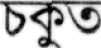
চকুত
